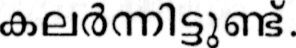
കലര്‍ന്നിട്ടുണ്ട്.
